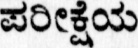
ಪರೀಕ್ಷೆಯ
